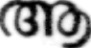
ആ
